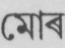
মোৰ
